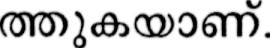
ത്തുകയാണ്.
